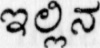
ಇಲ್ಲಿನ
